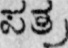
ಪತ್ರ
